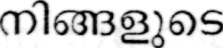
നിങ്ങളുടെ
